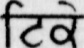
ਟਿਕੇ
